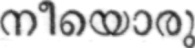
നീയൊരു
